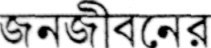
জনজীবনের
